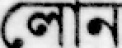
লোন
